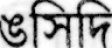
ঙসিদি
